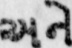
અને
